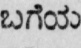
ಬಗೆಯ
